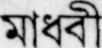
মাধবী
